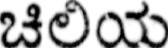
ಚಿಲಿಯ
